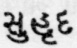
સુહૃદ
